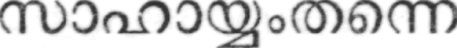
സാഹായ്യംതന്നെ
